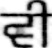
ਵੀ
